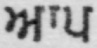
ਆਪ
